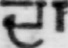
ਦਾ
